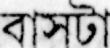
বাসটা
